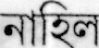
নাহিল
